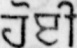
ਹੋਈ
